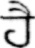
ਹੈ
